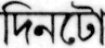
দিনটো
